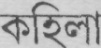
কহিলা
